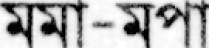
মমা-মপা
